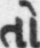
તો
